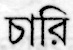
চারি
